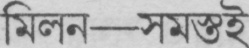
মিলন-সমস্তই
